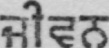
ਜੀਵਨ
